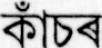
কাঁচৰ
